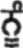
ਨੂੰ
